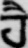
ਹੈ
